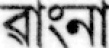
ৱাংনা
